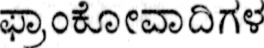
ಫ್ರಾಂಕೋವಾದಿಗಳ
